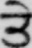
ਤੇ
